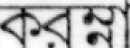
করম্না
